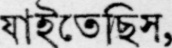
যাইতেছিস,
